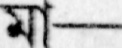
মা-
